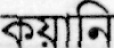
কয়ানি
